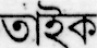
তাইক
